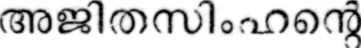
അജിതസിംഹന്റെ
